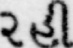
રહી
